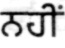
ਨਹੀਂ
